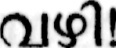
വഴി!
